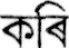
কৰি
